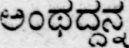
ಅಂಥದ್ದನ್ನ
